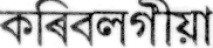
কৰিবলগীয়া
